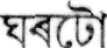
ঘৰটো
